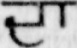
ਦਾ
